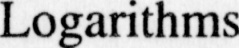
Logarithms
